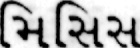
મિસિસ
